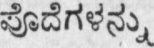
ಪೊದೆಗಳನ್ನು
